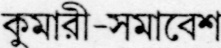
কুমারী-সমাবেশ
